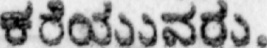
ಕರೆಯುವರು.
